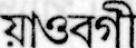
য়াওবগী
